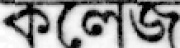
কলেজ
